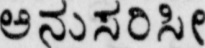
ಅನುಸರಿಸೀ
